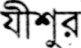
যীশুর
